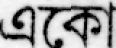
একো
